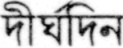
দীর্ঘদিন
